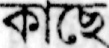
কাছে
